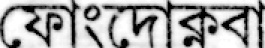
ফোংদোক্নবা
